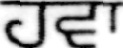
ਹਵਾ
